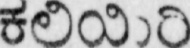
ಕಲಿಯಿರಿ
